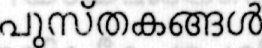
പുസ്തകങ്ങള്‍
